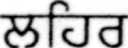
ਲਹਿਰ
